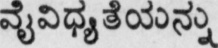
ವೈವಿಧ್ಯತೆಯನ್ನು
